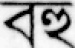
বহু
